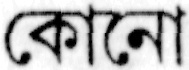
কোনো
